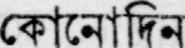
কোনোদিন
